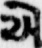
એ
